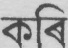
কৰি
